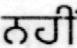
ਨਹੀਂ
